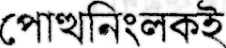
পোত্থনিংলকই
